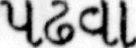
પઢવા
